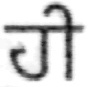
ਹੀ
